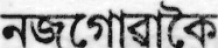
নজগোৱাকৈ
